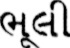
ભૂલી
